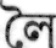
লৈ
